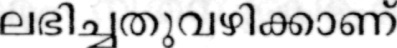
ലഭിച്ചതുവഴിക്കാണ്
